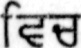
ਵਿਚ
